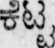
ಕೆಟ್ಟ
